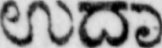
ಉದಾ
